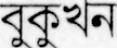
বুকুখন
